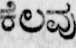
ಕೆಲವು
